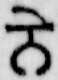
ਨੇ
